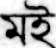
মই
